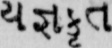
યજ્ઞકૃત
